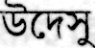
উদেসু
